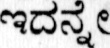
ಇದನ್ನೇ
